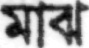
মাঝ
